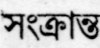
সংক্রান্ত
